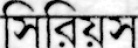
সিরিয়স
